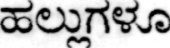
ಹಲ್ಲುಗಳೂ
